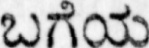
ಬಗೆಯ
